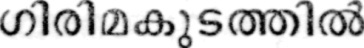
ഗിരിമകുടത്തില്‍
